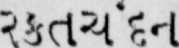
રક્તચંદન
